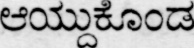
ಆಯ್ದುಕೊಂಡ
